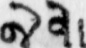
જેવો
